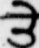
ਤੇ
